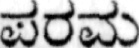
ಪರಮ
